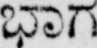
ಭಾಗ
